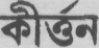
কীৰ্ত্তন
